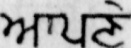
ਆਪਣੇ
